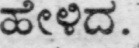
ಹೇಳಿದ.
